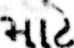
માટે
